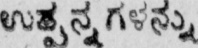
ಉತ್ಪನ್ನಗಳನ್ನು
